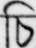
চি
